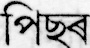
পিছৰ
